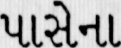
પાસેના
